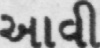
આવી
